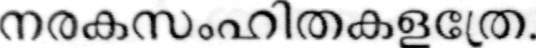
നരകസംഹിതകളത്രേ.
